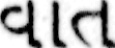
વાત
